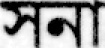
সনা
